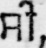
ਸੀ,
